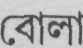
বোলা
